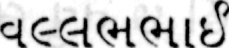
વલ્લભભાઈ
